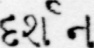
દર્શન
